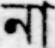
না
